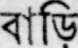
বাড়ি
